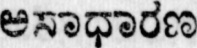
ಅಸಾಧಾರಣ
